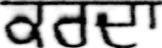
ਕਰਦਾ
